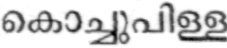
കൊച്ചുപിള്ള
